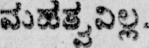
ಮಹತ್ವವಿಲ್ಲ.
